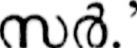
സര്‍.’
